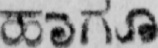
ಹಾಗೂ
